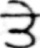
ਤੇ
